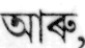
আৰু,
